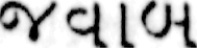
જવાબ
